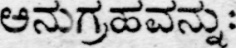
ಅನುಗ್ರಹವನ್ನು:
